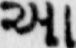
આ
